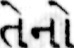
તેનો
